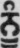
ਨੂੰ
